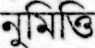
নুমিত্তি
